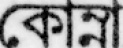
কোম্না
